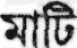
মাটি
